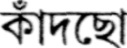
কাঁদছো
